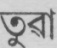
তুৱা
